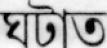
ঘটাত
